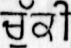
ਚੁੱਕੀ
